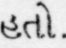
હતો.
